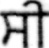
ਸੀ
